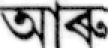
আৰু
